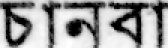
চানবা
